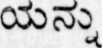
ಯನ್ನು
